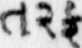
તરફ
